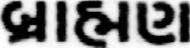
બ્રાહ્મણ
